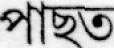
পাছত
